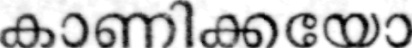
കാണിക്കയോ
